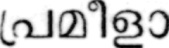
പ്രമീളാ
